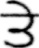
ਤੇ
